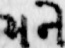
મને
